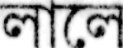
লালে
